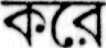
করে
